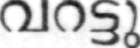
വറട്ടു
